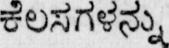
ಕೆಲಸಗಳನ್ನು
